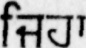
ਜਿਹਾ
